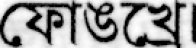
ফোঙখ্রে।
